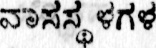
ವಾಸಸ್ಥಳಗಳ
